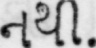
નથી.
